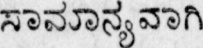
ಸಾಮಾನ್ಯವಾಗಿ
